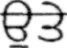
ਉਤੇ
